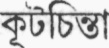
কূটচিন্তা
